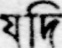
যদি
